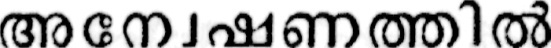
അന്വേഷണത്തില്‍
